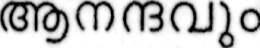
ആനന്ദവും
